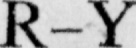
R-Y
